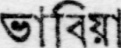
ভাবিয়া
